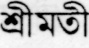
শ্রীমতী
